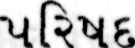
પરિષદ
